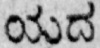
ಯದ
